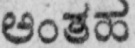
ಅಂತಹ
